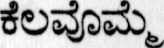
ಕೆಲವೊಮ್ಮೆ
